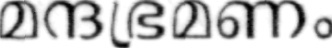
മന്ദഭ്രമണം
